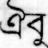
ঐবু
